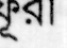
ফূরা
